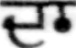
ਦਾ
